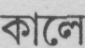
কালে
